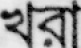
খরা
